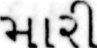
મારી
